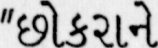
"છોકરાને
